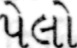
પેલો
